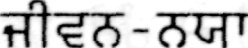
ਜੀਵਨ-ਨਯਾ
